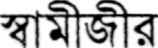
স্বামীজীর
